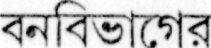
বনবিভাগের
